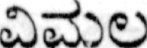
ವಿಮಲ
